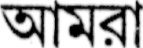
আমরা
